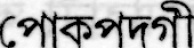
পোকপদগী
